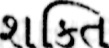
શક્તિ
